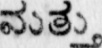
ಮತ್ತು
